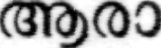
ആരാ
